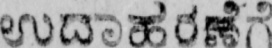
ಉದಾಹರಣೆಗೆ
